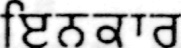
ਇਨਕਾਰ
